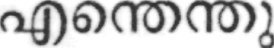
എന്തെന്തു
